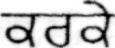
ਕਰਕੇ
